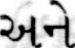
અને
